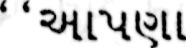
"આપણા
